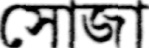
সোজা
